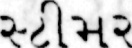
સ્ટીમર
